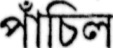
পাঁচিল
